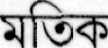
মতিক
